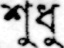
শুধু
